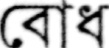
বোধ
